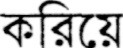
করিয়ে
